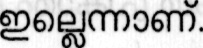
ഇല്ലെന്നാണ്.
